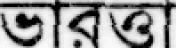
ভারত্তা
